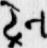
ટ્રેન
